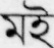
মই
